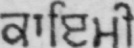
ਕਾਇਮੀ
